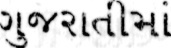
ગુજરાતીમાં
